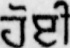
ਹੋਈ
